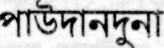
পাউদানদুনা
